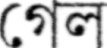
গেল
